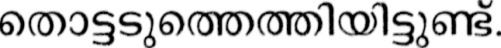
തൊട്ടടുത്തെത്തിയിട്ടുണ്ട്.
